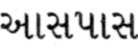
આસપાસ
